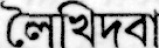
লৈখিদবা
